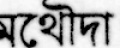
মথৌদা
